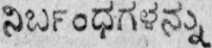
ನಿರ್ಬಂಧಗಳನ್ನು
